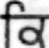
ਕਿ
